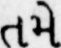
તમે
